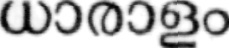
ധാരാളം
